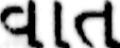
વાત
